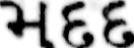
મદદ
